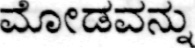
ಮೋಡವನ್ನು
